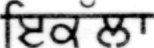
ਇਕੱਲਾ
